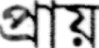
প্রায়
